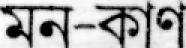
মন-কাণ
